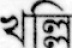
খল্লি
